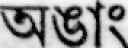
অঙাং
